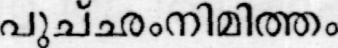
പുച്ഛംനിമിത്തം
